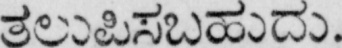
ತಲುಪಿಸಬಹುದು.
